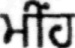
ਮੀਂਹ
